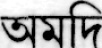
অমদি
